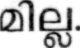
മില്ല.
